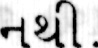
નથી.
